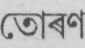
তোৰণ
